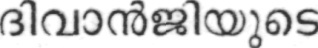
ദിവാന്‍ജിയുടെ
